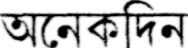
অনেকদিন
